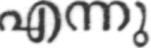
എന്നു
